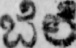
ಬೆಲೆ
